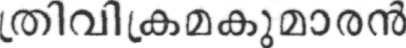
ത്രിവിക്രമകുമാരന്‍
